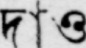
দাও
